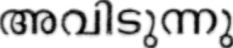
അവിടുന്നു
